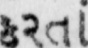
કરતાં
